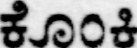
ಕೊಂಕಿ
